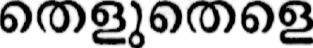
തെളുതെളെ
